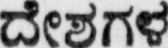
ದೇಶಗಳ
